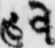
હવે
